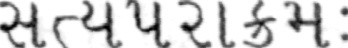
સત્યપરાક્રમઃ
